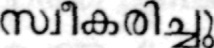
സ്വീകരിച്ചു
